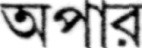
অপার
